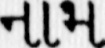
નામ
